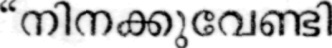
"നിനക്കുവേണ്ടി
